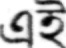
এই
